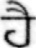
ਹੈ
